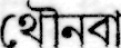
থৌনবা
